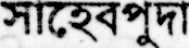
সাহেবপুদা
